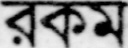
রকম
